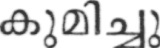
കുമിച്ചു
